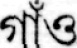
গাঁও
